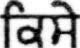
ਕਿਸੇ
